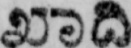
ಖಾದಿ
